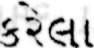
કરેલા
